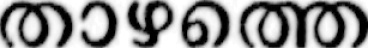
താഴത്തെ
